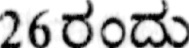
26ರಂದು
